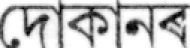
দোকানৰ
